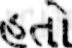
હતો
